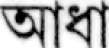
আধা
